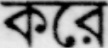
করে
